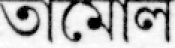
তামোল
